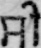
ਸੀ
